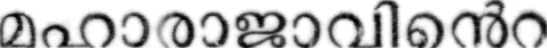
മഹാരാജാവിന്റെ
